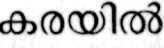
കരയില്‍
